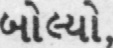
બોલ્યો,
